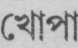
খোপা
